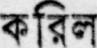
করিল
